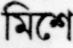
মিশে
